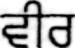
ਵੀਰ
